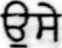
ਉਸੇ
